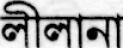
লীলানা
